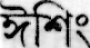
ঈশিং
